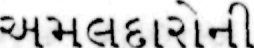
અમલદારોની
